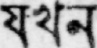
যখন
